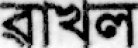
ৱাখল
